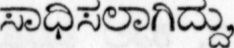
ಸಾಧಿಸಲಾಗಿದ್ದು,
